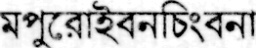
মপুরোইবনচিংবনা
